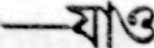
–যাও
